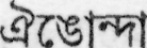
ঐঙোন্দা
